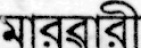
মারৱারী
